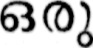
ഒരു
